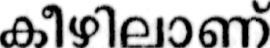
കീഴിലാണ്
